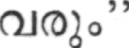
വരും"
